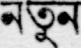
নতুন
